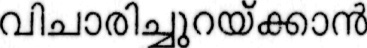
വിചാരിച്ചുറയ്ക്കാന്‍
